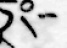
চুং-
